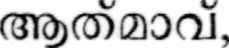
ആത്മാവ്,
